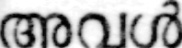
അവള്‍
